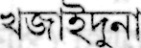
খজাইদুনা
